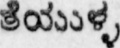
ತೆಯುಳ್ಳ
